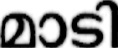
മാടി
